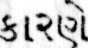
કારણે
